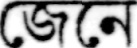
জেনে
